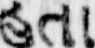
હતા
